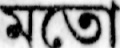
মতো
